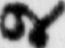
જ
